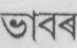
ভাবৰ
